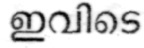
ഇവിടെ
